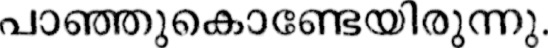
പാഞ്ഞുകൊണ്ടേയിരുന്നു.
